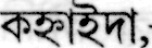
কহ্নাইদা,
